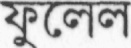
ফুলেল
